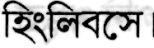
হিংলিবসে
